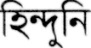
হিন্দুনি
